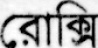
রোক্সি
